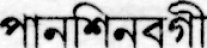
পানশিনবগী
